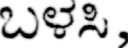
ಬಳಸಿ,
